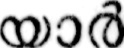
യാര്‍
